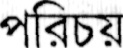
পরিচয়
